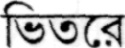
ভিতরে
